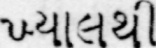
ખ્યાલથી
